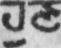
ਹੁਣ
